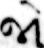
જો
